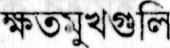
ক্ষতমুখগুলি
